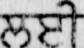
ਲਈ
